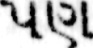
પણ
